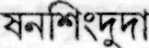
ষনশিংদুদা
